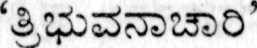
‘ತ್ರಿಭುವನಾಚಾರಿ’
